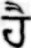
ਹੈ
